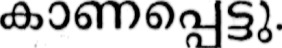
കാണപ്പെട്ടു.
